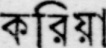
করিয়া
